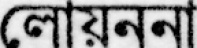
লোয়ননা
